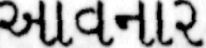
આવનાર
